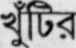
খুঁটির
